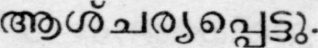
ആശ്ചര്യപ്പെട്ടു.
